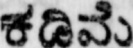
ಕಡಿಮೆ
